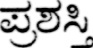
ಪ್ರಶಸ್ತಿ
